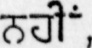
ਨਹੀਂ,
